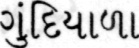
ગુંદિયાળા
